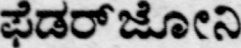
ಫೆಡರ್‌ಜೋನಿ
